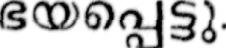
ഭയപ്പെട്ടു.
